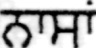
ਨਾਸਾਂ
